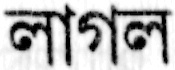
লাগল
